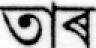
তাৰ
